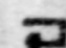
ਦ
